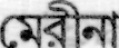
মেরীনা
